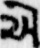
એ
